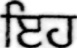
ਇਹ
